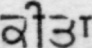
ਕੀਤਾ
